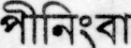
পীনিংবা
